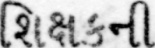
શિક્ષકની
